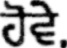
ਹੋਵੇ,
